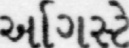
ર્આગસ્ટે
